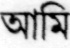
আমি
